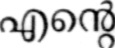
എന്റെ
